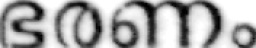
ഭരണം
